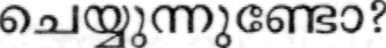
ചെയ്യുന്നുണ്ടോ?
